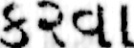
કરવા
